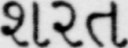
શરત
